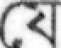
যে
